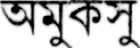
অমুকসু
